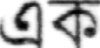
এক
